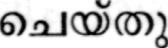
ചെയ്തു
